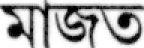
মাজত
